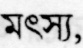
মত্স্য,
